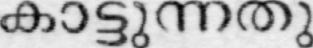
കാട്ടുന്നതു
